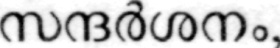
സന്ദര്‍ശനം,
